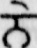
ਨੇ
